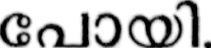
പോയി.
